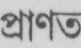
প্ৰাণত
